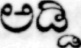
ಅಡ್ಡಿ
